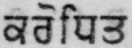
ਕਰੋਧਿਤ
